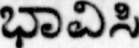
ಭಾವಿಸಿ
